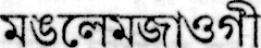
মঙলেমজাওগী
